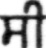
ਸੀ
